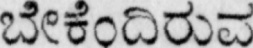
ಬೇಕೆಂದಿರುವ
